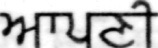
ਆਪਣੀ
